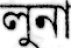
লুনা
